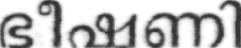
ഭീഷണി
